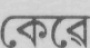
কেৱে
